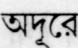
অদূরে
